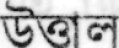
উত্তাল
